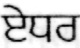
ਏਧਰ
